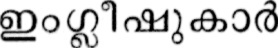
ഇംഗ്ലീഷുകാര്‍
